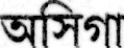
অসিগা
